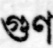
গুণ
